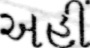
અહીં
